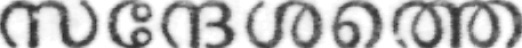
സന്ദേശത്തെ
